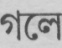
গলে
